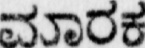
ಮಾರಕ
